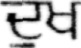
ਦੁਖ
